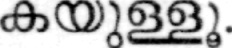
കയുള്ളൂ.
